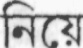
নিয়ে
